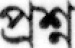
প্রশ্ন
